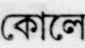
কোলে
